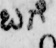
ಬಗ್ಗೆ
